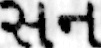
સન
